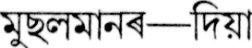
মুছলমানৰ-দিয়া
